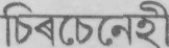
চিৰচেনেহী
